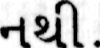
નથી.
